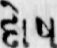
દોષ
